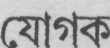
যোগক
